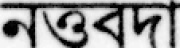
নত্তবদা
